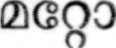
മറ്റോ
